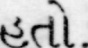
હતો.
